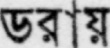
ডরায়
